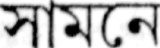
সামনে
